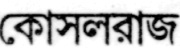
কোসলরাজ
